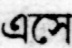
এসে
